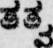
ತತ್ವ
